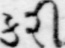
કરી
